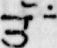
ਤੋਂ
